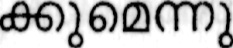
ക്കുമെന്നു
